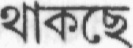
থাকছে
